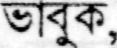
ভাবুক,
